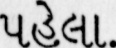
પહેલા.
